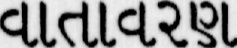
વાતાવરણ
